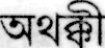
অথক্কী
